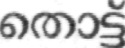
തൊട്ട്
